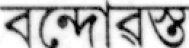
বন্দোৱস্ত
